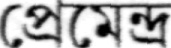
প্রেমেন্দ্র
